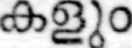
കളും
